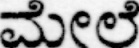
ಮೇಲೆ
